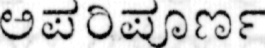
ಅಪರಿಪೂರ್ಣ
